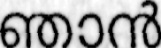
ഞാന്‍
